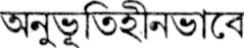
অনুভূতিহীনভাবে
